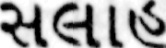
સલાહ
